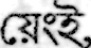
য়েংই,
